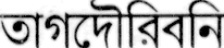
তাগদৌরিবনি
